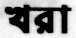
খরা
